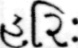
હરિઃ
